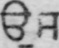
ਉਸ
